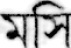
মসি
